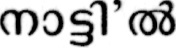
നാട്ടി’ല്‍
